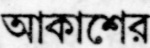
আকাশের
